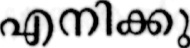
എനിക്കു
